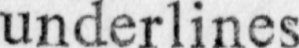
underlines
